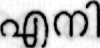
എനി
